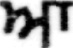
ਆ
